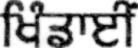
ਖਿੰਡਾਈਂ
